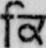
ਕਿ
